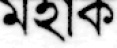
মহাক
